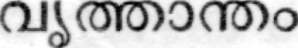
വൃത്താന്തം
